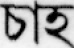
চাহ
